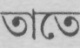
তাতে
